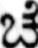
ಚೆ
